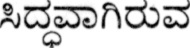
ಸಿದ್ಧವಾಗಿರುವ
